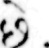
છે.
